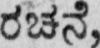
ರಚನೆ,
